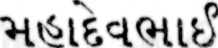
મહાદેવભાઈ
